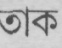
তাক
